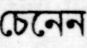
চেনেন
